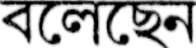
বলেছেন
